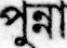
পুন্না
